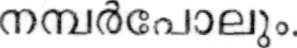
നമ്പര്‍പോലും.
